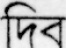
দিব
